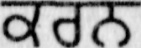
ਕਰਨ
